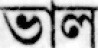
ভাল
